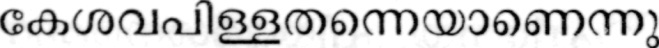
കേശവപിള്ളതന്നെയാണെന്നു
